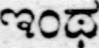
ಇಂಥ
